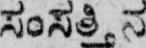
ಸಂಸತ್ತಿನ
